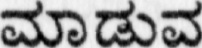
ಮಾಡುವ
